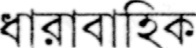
ধারাবাহিক
